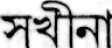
সখীনা
